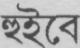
হুইবে
